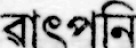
ৱাৎপনি
